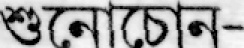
শুনোচোন-
